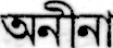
অনীনা
